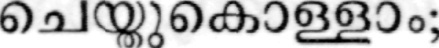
ചെയ്തുകൊള്ളാം;
